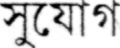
সুযোগ
